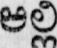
ಅಲ್ಲಿ
